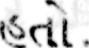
હતો.
